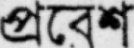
প্রবেশ
